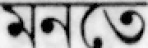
মনতে
